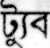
ট্যুব
